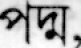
পদ্ম,
